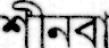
শীনবা
